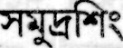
সমুদ্রশিং
